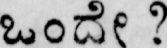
ಒಂದೇ?
